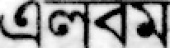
এলবম
